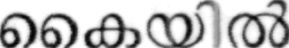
കൈയില്‍
